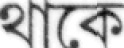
থাকে
